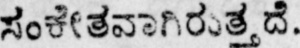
ಸಂಕೇತವಾಗಿರುತ್ತದೆ.
